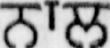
ਨਾਲ
